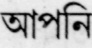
আপনি
